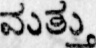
ಮತ್ತು
